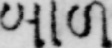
બાળ
